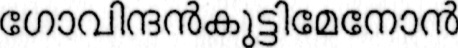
ഗോവിന്ദന്‍കുട്ടിമേനോന്‍
